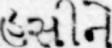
હસીને
